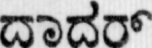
ದಾದರ್
